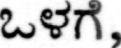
ಒಳಗೆ,
